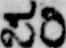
ಪರಿ
